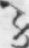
કે
